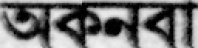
অকনবা
